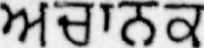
ਅਚਾਨਕ
